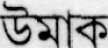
উমাক
